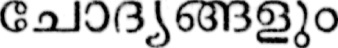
ചോദ്യങ്ങളും
